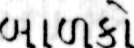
બાળકો
